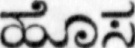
ಹೊಸ
